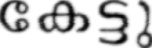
കേട്ടു
